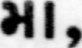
મા,
